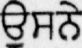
ਉਸਨੇ
